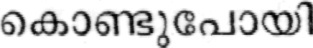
കൊണ്ടുപോയി
